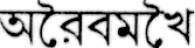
অরৈবমখৈ
